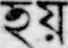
হয়
